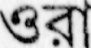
ওরা
